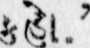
કહો.'
